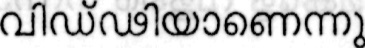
വിഡ്ഢിയാണെന്നു
